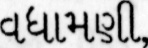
વધામણી,
